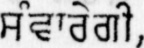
ਸੰਵਾਰੇਗੀ,
